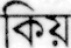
কিয়
